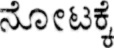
ನೋಟಕ್ಕೆ
